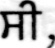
ਸੀ,
